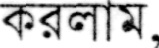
করলাম,
